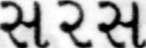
સરસ
